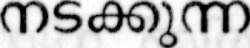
നടക്കുന്ന
